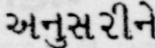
અનુસરીને
